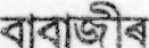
বাবাজীৰ
